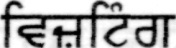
ਵਿਜ਼ਟਿੰਗ
